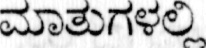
ಮಾತುಗಳಲ್ಲಿ
